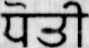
ਧੋਤੀ
